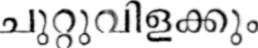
ചുറ്റുവിളക്കും
